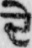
ਦੇ
